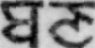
ਬਣ
